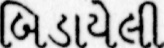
બિડાયેલી
